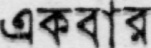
একবার
